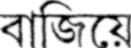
বাজিয়ে
